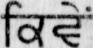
ਕਿਵੇਂ
